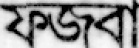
ফজবা
